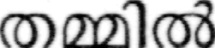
തമ്മില്‍
